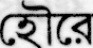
হৌরে
